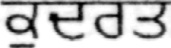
ਕੁਦਰਤ
